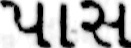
પાસ
